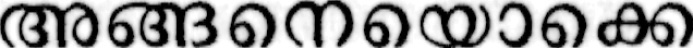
അങ്ങനെയൊക്കെ
